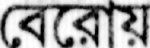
বেরোয়
